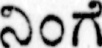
ನಿಂಗೆ
